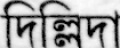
দিল্লিদা
